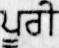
ਪੂਰੀ
